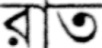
রাত
